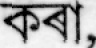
কৰা,
